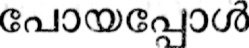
പോയപ്പോള്‍
